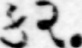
કર.
